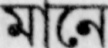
মানে
